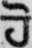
ਹੋ
